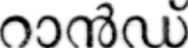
റാന്‍ഡ്
